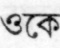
ওকে
